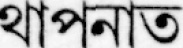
থাপনাত
